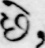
છે,
